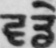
ਵਡੇ
